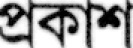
প্রকাশ
